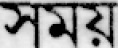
সময়
